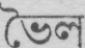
ভৈল
